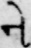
ને
